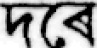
দৰে
